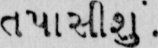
તપાસીશું.
